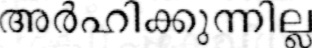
അര്‍ഹിക്കുന്നില്ല
